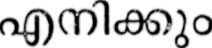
എനിക്കും
